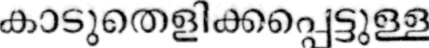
കാടുതെളിക്കപ്പെട്ടുള്ള
